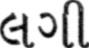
લગી
